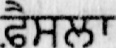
ਫ਼ੈਸਲਾ
